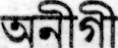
অনীগী
